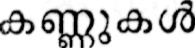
കണ്ണുകള്‍
